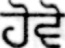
ਹੋਵੋ
